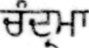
ਚੰਦ੍ਰਮਾ
